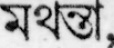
মথন্তা,
